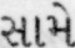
સામે
